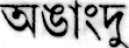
অঙংদু
